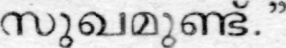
സുഖമുണ്ട്.”
